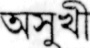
অসুখী
